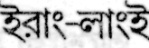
ইরাং-লাংই
